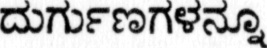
ದುರ್ಗುಣಗಳನ್ನೂ
